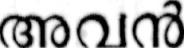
അവന്‍
